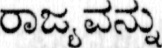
ರಾಜ್ಯವನ್ನು
